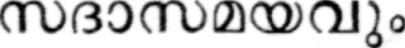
സദാസമയവും
